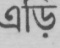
এড়ি
